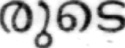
രുടെ
